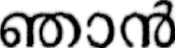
ഞാന്‍
